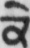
ਕੇ
